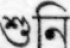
শুনি
